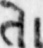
તો
